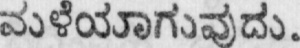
ಮಳೆಯಾಗುವುದು.
